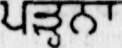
ਪੜ੍ਹਨਾ
